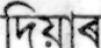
দিয়াৰ
